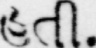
હતી.
